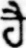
ਹੈ
